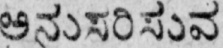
ಅನುಸರಿಸುವ
